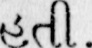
હતી.
